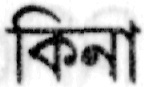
কিনা
